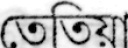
তেতিয়া
